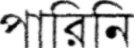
পারিনি
